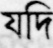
যদি
